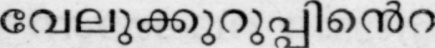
വേലുക്കുറുപ്പിന്റെ
